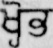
ਖ੍ਹੋਭ
